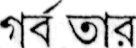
গর্ব তার
